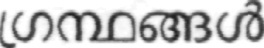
ഗ്രന്ഥങ്ങള്‍
